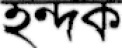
হন্দক
